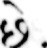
છે.
